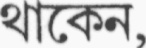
থাকেন,
